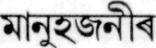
মানুহজনীৰ
